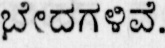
ಬೇದಗಳಿವೆ.
